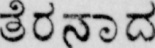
ತೆರನಾದ
